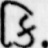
કિ.
